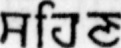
ਸਹਿਣ
